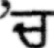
'ਚ
